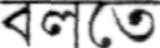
বলতে
